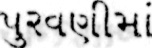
પુરવણીમાં
